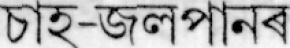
চাহ-জলপানৰ
